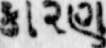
કારણ
